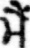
ਮੈਂ
